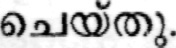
ചെയ്തു.
